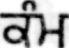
ਕੰਮ
